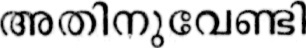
അതിനുവേണ്ടി
